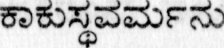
ಕಾಕುಸ್ಥವರ್ಮನು
